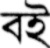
বই
